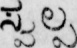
ಸ್ವಲ್ಪ
